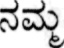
ನಮ್ಮ
